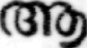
ആ
